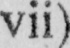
vii)
